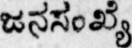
ಜನಸಂಖ್ಯೆ
